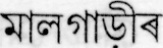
মালগাড়ীৰ
